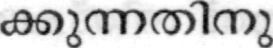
ക്കുന്നതിനു
